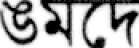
ঙমদে
